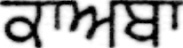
ਕਾਅਬਾ
